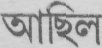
আছিল
